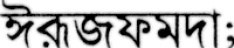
ঈরূজফমদা;
